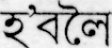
হ'বলৈ
